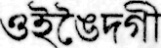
ওইঙৈদগী
